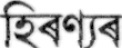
হিৰণ্যৰ
